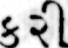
કરી
